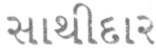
સાથીદાર
